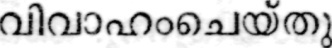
വിവാഹംചെയ്തു
